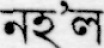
নহ'ল
